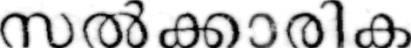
സല്‍ക്കാരിക
